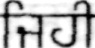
ਜਿਹੀ
